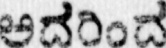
ಅದರಿಂದ
